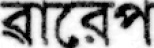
ৱারেপ
